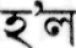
হ'ল
